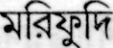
মরিফুদি
